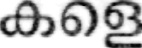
കളെ
